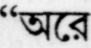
“অরে
